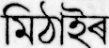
মিঠাইৰ
